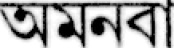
অমনবা
